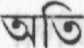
অতি
